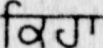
ਕਿਹਾ
